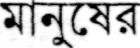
মানুষের
